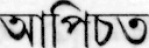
আপিচত
